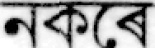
নকৰে
